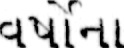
વર્ષોના
